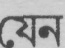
যেন
